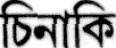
চিনাকি
